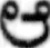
ಆ
